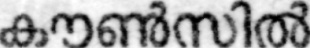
കൌണ്‍സില്‍
